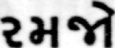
રમજો
